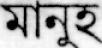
মানুহ
